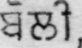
ਬੋਲੀ,
